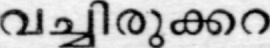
വച്ചിരുക്കറ
